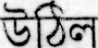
উঠিল
